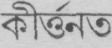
কীৰ্ত্তনত
